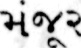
મંજૂર
